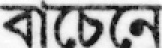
বাচেনে
